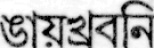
ঙায়খ্রবনি
